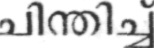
ചിന്തിച്ച്
